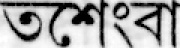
তশেংবা
